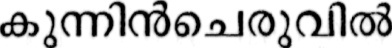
കുന്നിന്‍ചെരുവില്‍
